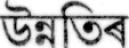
উন্নতিৰ
